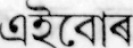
এইবোৰ
